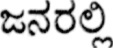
ಜನರಲ್ಲಿ
